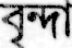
বৃন্দা
